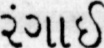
રંગાઈ
